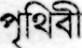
পৃথিবী
